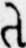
તે
